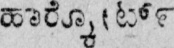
ಹಾರ್‍ಕೋರ್ಟ್
